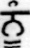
ਨੂੰ
